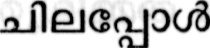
ചിലപ്പോള്‍
